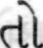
તો
